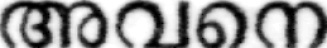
അവനെ
